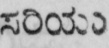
ಸರಿಯು
